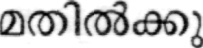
മതില്‍ക്കു
